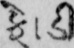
ફોડી
